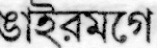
ঙাইরমগে
